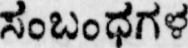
ಸಂಬಂಧಗಳ
